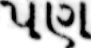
પણ
